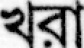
খরা
